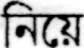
নিয়ে
